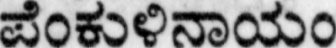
ಪೆಂಕುಳಿನಾಯಂ
